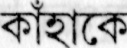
কাঁহাকে
